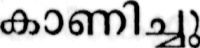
കാണിച്ചു
